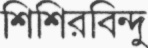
শিশিরবিন্দু
